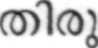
തിരു
